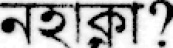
নহাক্না?
